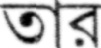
তার
